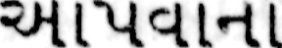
આપવાના
